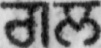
ਗਲ
